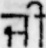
ਜੀ
